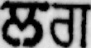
ਲਗ
